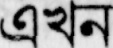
এখন
